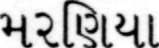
મરણિયા
